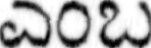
ಎಂಬ
